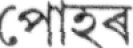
পোহৰ
